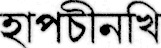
হাপচীনখি
